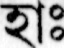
হাঃ
